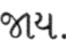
જાય.
